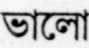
ভালো
